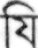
যি
